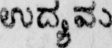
ಉದ್ಯಮ
